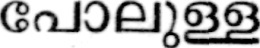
പോലുള്ള
